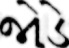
જોડે
